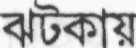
ঝটকায়
